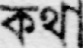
কথা
